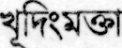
খূদিংমক্তা
